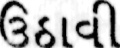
ઉઠાવી
